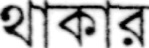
থাকার
